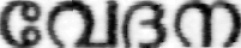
വേദന
